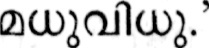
മധുവിധു.'
